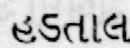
હડતાલ
